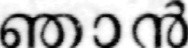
ഞാന്‍
